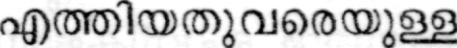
എത്തിയതുവരെയുള്ള
